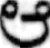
ಆ
